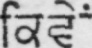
ਕਿਵੇਂ
